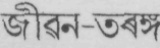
জীৱন-তৰঙ্গ
